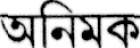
অনিমক
